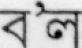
ব'ল
